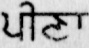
ਪੀਣਾ
